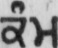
ਕੰਮ
